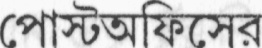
পোস্টঅফিসের
